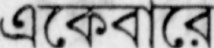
একেবারে
